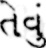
તેવું
